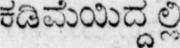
ಕಡಿಮೆಯಿದ್ದಲ್ಲಿ
